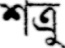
শত্রু
